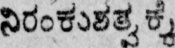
ನಿರಂಕುಶತ್ವಕ್ಕೆ
